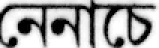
নেনাচে
